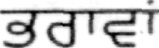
ਭਰਾਵਾਂ
